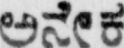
ಅನೇಕ
